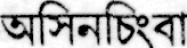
অসিনচিংবা
